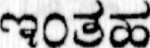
ಇಂತಹ
